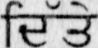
ਦਿੱਤੇ
